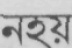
নহয়
